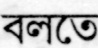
বলতে
